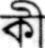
কী
